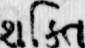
શક્તિ
